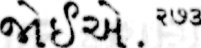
જોઈએ.૨૭૩
